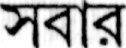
সবার
